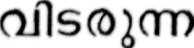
വിടരുന്ന
